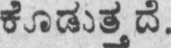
ಕೊಡುತ್ತದೆ.
